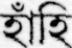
হাঁহি
